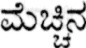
ಮೆಚ್ಚಿನ
